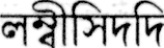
লম্বীসিদদি
